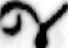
જ
